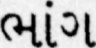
ભાંગ
